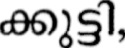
ക്കുട്ടി,
